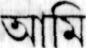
আমি
